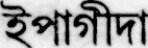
ইপাগীদা
